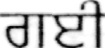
ਗਈ
